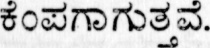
ಕೆಂಪಗಾಗುತ್ತವೆ.
